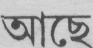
আছে
